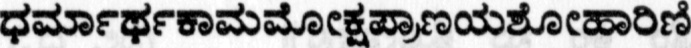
ಧರ್ಮಾರ್ಥಕಾಮಮೋಕ್ಷಪ್ರಾಣಯಶೋಹಾರಿಣಿ
